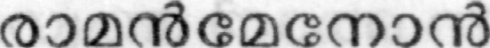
രാമന്‍മേനോന്‍
